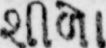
શીળો
